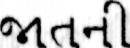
જાતની
